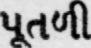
પૂતળી
